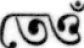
তেওঁ
